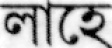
লাহে
